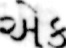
એક
